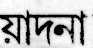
য়াদনা
